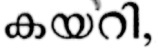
കയറി,
